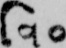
વિ.
